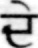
ਦੇ
